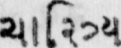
ચારિત્ર્ય
